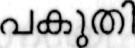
പകുതി
